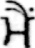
ਮੈਂ
